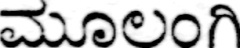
ಮೂಲಂಗಿ
